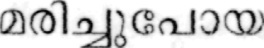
മരിച്ചുപോയ
